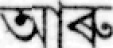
আৰু
